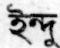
ইন্দু
